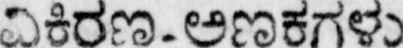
ವಿಕಿರಣ-ಅಣಕಗಳು
